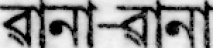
ৱানা-ৱানা
